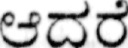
ಆದರೆ
